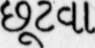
છૂટવા
